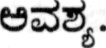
ಅವಶ್ಯ.
